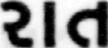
રાત
